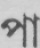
পা
